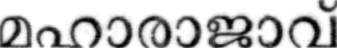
മഹാരാജാവ്
